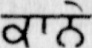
ਕਾਨੇ
